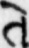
તે
